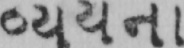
વ્યયના
